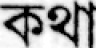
কথা
